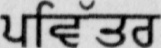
ਪਵਿੱਤਰ
